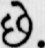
છે.
